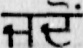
ਜਦੋਂ
